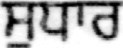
ਸੁਧਾਰ
